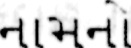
નામનો
